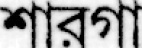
শাদুনা
